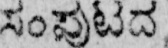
ಸಂಪುಟದ
